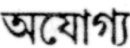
অযোগ্য
